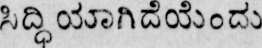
ಸಿದ್ಧಿಯಾಗಿದೆಯೆಂದು
